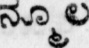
ನ್ಮೂಲ
